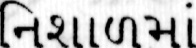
નિશાળમાં
